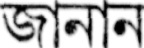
জানান
